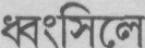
ধ্বংসিলে
